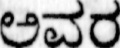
ಅವರ
